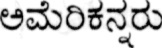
ಅಮೆರಿಕನ್ನರು
